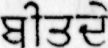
ਬੀਤਦੇ
